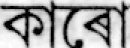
কাৰো
